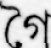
গৈ
